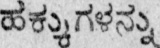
ಹಕ್ಕುಗಳನ್ನು
